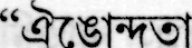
“ঐঙোন্দতা
